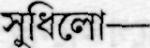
সুধিলো-
